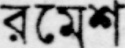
রমেশ
